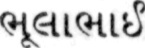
ભૂલાભાઈ
